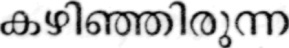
കഴിഞ്ഞിരുന്ന
